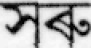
সৰু
